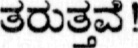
ತರುತ್ತವೆ!
